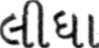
લીધા
